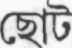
ছোট
